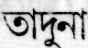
তাদুনা
